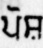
ਪੋਸ਼
